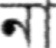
না
